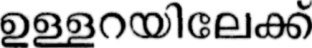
ഉള്ളറയിലേക്ക്
